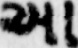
આ
